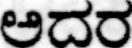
ಅದರ
